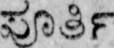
ಪೂರ್ತಿ
